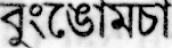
বুংঙোমচা
